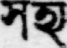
সহ্য
